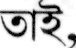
তাই,
